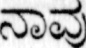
ನಾವು
